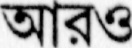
আরও
